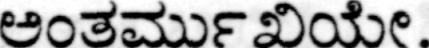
ಅಂತರ್ಮುಖಿಯೇ.
